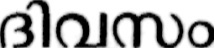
ദിവസം
